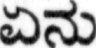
ಏನು
